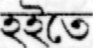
হইতে
